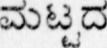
ಮಟ್ಟದ
